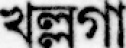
খল্লগা
